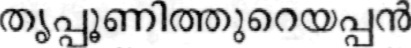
തൃപ്പൂണിത്തുറെയപ്പന്‍
